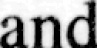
and
